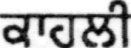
ਕਾਹਲੀ
